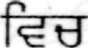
ਵਿਚ
